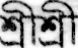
শ্রীশ্রী
